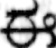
ಈ
